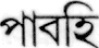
পাবহি
